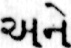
અને
